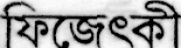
ফিজেৎকী
